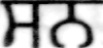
ਸਨ
